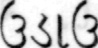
ઉડાઉ
